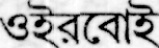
ওইরবোই
